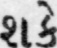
શકે
